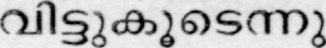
വിട്ടുകൂടെന്നു
